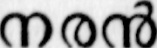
നരന്‍
